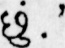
છું.'
